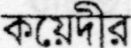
কয়েদীর
